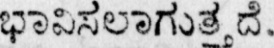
ಭಾವಿಸಲಾಗುತ್ತದೆ.
